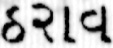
ઠરાવ
